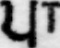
ਪਾ
